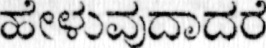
ಹೇಳುವುದಾದರೆ
